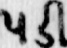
પડી
